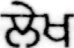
ਲੇਖ
